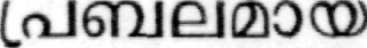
പ്രബലമായ
